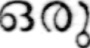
ഒരു
